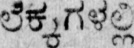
ಲೆಕ್ಕಗಳಲ್ಲಿ
